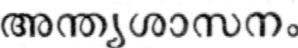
അന്ത്യശാസനം
